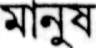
মানুষ
